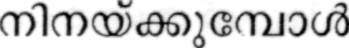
നിനയ്ക്കുമ്പോള്‍
